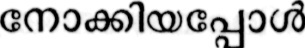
നോക്കിയപ്പോള്‍
